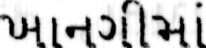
ખાનગીમાં
